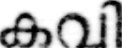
കവി
